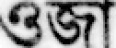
ওজা
